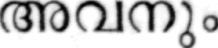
അവനും
